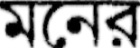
মনের
